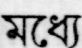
মধ্যে
